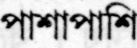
পাশাপাশি
